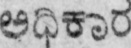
ಅಧಿಕಾರ
